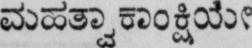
ಮಹತ್ವಾಕಾಂಕ್ಷಿಯೇ
